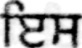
ਇਸ
